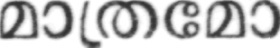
മാത്രമോ
